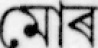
মোৰ
